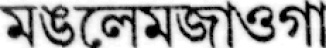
মঙলেমজাওগা
